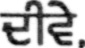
ਦੀਵੇ,
